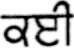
ਕਈ
